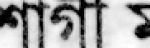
শাগী
